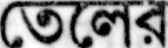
তেলের
